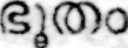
ഭൂതം
